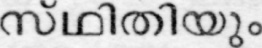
സ്ഥിതിയും
